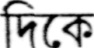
দিকে
